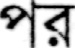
পর
